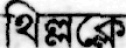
থিল্লক্লে
